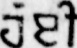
ਹੋਈ
